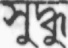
সুদ্ধু
